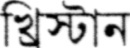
খ্রিস্টান
